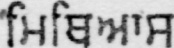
ਮਿਥਿਆਸ
